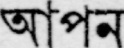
আপন
